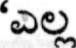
‘ಎಲ್ಲ
